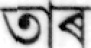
তাৰ
